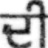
ਦੀ
